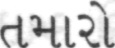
તમારો
